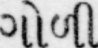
ગોળી
